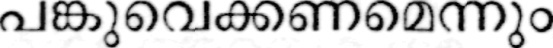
പങ്കുവെക്കണമെന്നും
